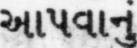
આપવાનું
